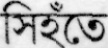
সিহঁতে
